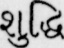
શુદ્ધિ
